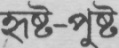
হৃষ্ট-পুষ্ট
